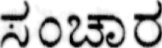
ಸಂಚಾರ
